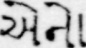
એનો
